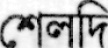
শেলদি
